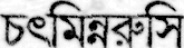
চৎমিন্নরুসি
